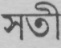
সতী
